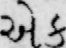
એક
